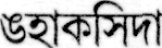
ঙহাকসিদা
